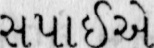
સપાઈએ
